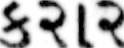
કરાર
